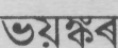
ভয়ঙ্কৰ
